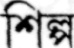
শিল্প
